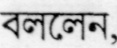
বললেন,
